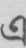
এ
